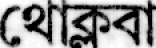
থোক্লবা
